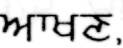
ਆਖਣ,
